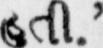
હતી.'
